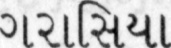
ગરાસિયા
